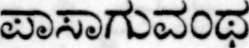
ಪಾಸಾಗುವಂಥ
